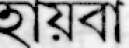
হায়বা
